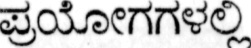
ಪ್ರಯೋಗಗಳಲ್ಲಿ
